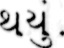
થયું.
